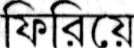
ফিরিয়ে
